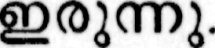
ഇരുന്നു.
